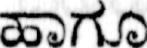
ಹಾಗೂ
